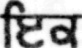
ਇਕ
